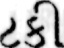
ટકી
